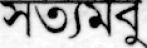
সত্যমবু
